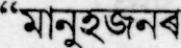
"মানুহজনৰ
